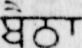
ਬੈਠਾ
